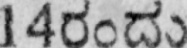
14ರಂದು
